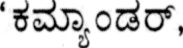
'ಕಮ್ಯಾಂಡರ್,
